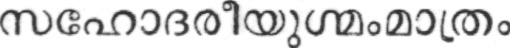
സഹോദരീയുഗ്മംമാത്രം
